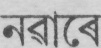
নৱাৰে
